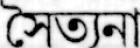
সৈত্যনা
